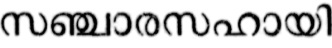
സഞ്ചാരസഹായി
